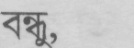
বন্ধু,
